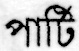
পার্টি
